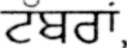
ਟੱਬਰਾਂ,
